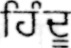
ਹਿੰਦੂ
